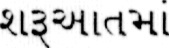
શરૂઆતમાં
